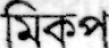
মিকপ
